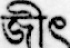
জীৎ
